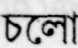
চলো
